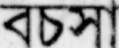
বচসা
